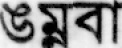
ঙম্নবা
